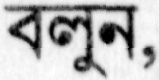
বলুন,
